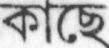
কাছে
